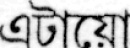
এটায়ো
